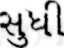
સુધી
